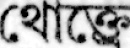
থোক্ত্রে
